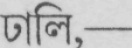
ঢালি,-
